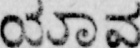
ಯಾವ
